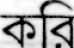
করি
